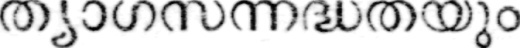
ത്യാഗസന്നദ്ധതയും
